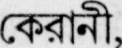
কেরানী,
